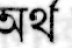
অর্থ
